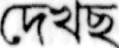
দেখছ
